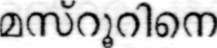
മസ്റൂറിനെ
